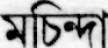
মচিন্দা
